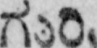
ಗುರಿ,
